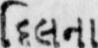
દિલના
